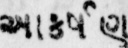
આકર્ષણ
